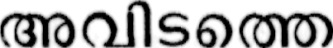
അവിടത്തെ
